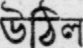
উঠিল
